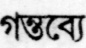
গন্তব্যে
